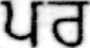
ਪਰ
